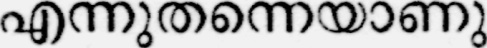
എന്നുതന്നെയാണു
